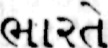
ભારતે
